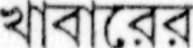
খাবারের
